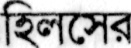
হিলসের
